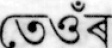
তেওঁৰ
